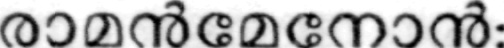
രാമന്‍മേനോന്‍:
